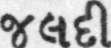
જલદી
